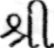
શ્રી
